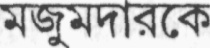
মজুমদারকে
